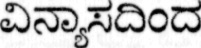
ವಿನ್ಯಾಸದಿಂದ
